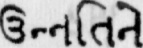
ઉન્નતિને
